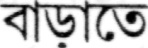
বাড়াতে
